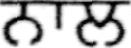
ਨਾਲ
